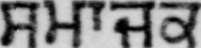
ਸਮਾਜਕ
